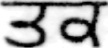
ਤਕ
